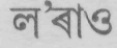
ল'ৰাও
